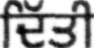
ਦਿੱਤੀ
